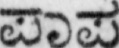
ಪಾಪ
